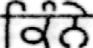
ਕਿੰਨੇ
